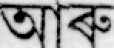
আৰু
